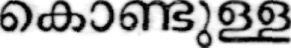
കൊണ്ടുള്ള
